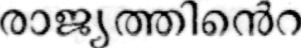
രാജ്യത്തിന്റെ
